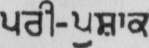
ਪਰੀ-ਪੁਸ਼ਾਕ
